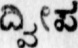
ದ್ವೀಪ
